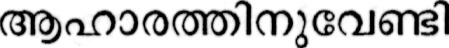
ആഹാരത്തിനുവേണ്ടി
